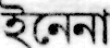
ইনেনা
